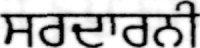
ਸਰਦਾਰਨੀ
